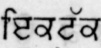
ਇਕਟੱਕ
